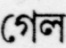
গেল
